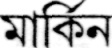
মার্কিন
